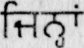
ਜਿਨ੍ਹਾਂ
